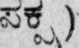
ಪಕ್ಷ)
